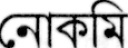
নোকমি
